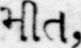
મીત,
